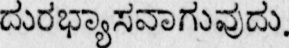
ದುರಭ್ಯಾಸವಾಗುವುದು.
